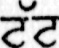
ਟੱਟ
